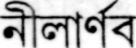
নীলার্ণব
